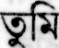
তুমি
